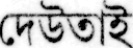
দেউতাই
